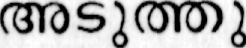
അടുത്തു
